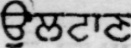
ਉਲਟਾਣ
